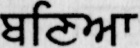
ਬਣਿਆ
